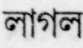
লাগল
